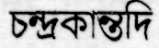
চন্দ্রকান্তদি
